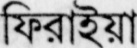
ফিরাইয়া
